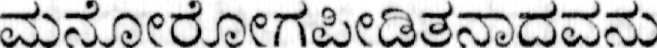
ಮನೋರೋಗಪೀಡಿತನಾದವನು
